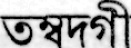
তম্বদগী
